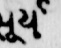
સૂર્ય
